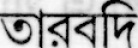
তারবদি
